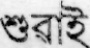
শুৱাই
